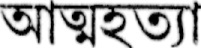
আত্মহত্যা
